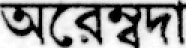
অরেম্বদা
